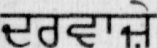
ਦਰਵਾਜ਼ੇ
